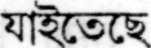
যাইতেছে
